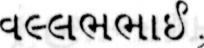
વલ્લભભાઈ,
